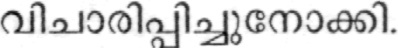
വിചാരിപ്പിച്ചുനോക്കി.
